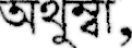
অথুম্বা,
